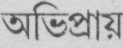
অভিপ্ৰায়
